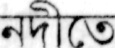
নদীতে
